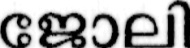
ജോലി
